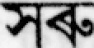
সৰু
